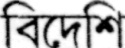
বিদেশি
